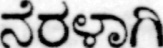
ನೆರಳಾಗಿ
